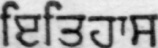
ਇਤਿਹਾਸ
